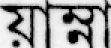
য়াম্না
